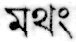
মথং
